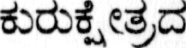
ಕುರುಕ್ಷೇತ್ರದ
